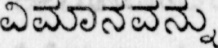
ವಿಮಾನವನ್ನು
